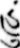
હું
